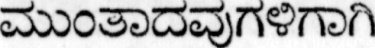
ಮುಂತಾದವುಗಳಿಗಾಗಿ
